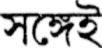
সঙ্গেই
